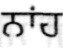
ਨਾਂਹ
